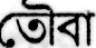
তৌবা
